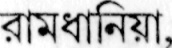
রামধানিয়া,
